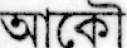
আকৌ
